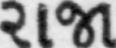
રાજા
